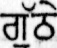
ਗੁੱਠੇ
